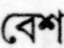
বেশ
